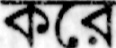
করে
